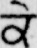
ਕੇ
